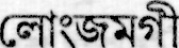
লোংজমগী
